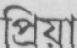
প্ৰিয়া
